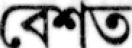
বেশত
